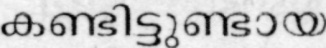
കണ്ടിട്ടുണ്ടായ
